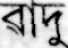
ৱাদু
